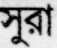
সুরা
